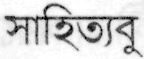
সাহিত্যবু
